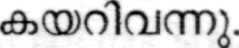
കയറിവന്നു.
